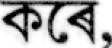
কৰে,
